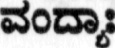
ವಂದ್ಯಾಃ
